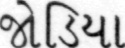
જોડિયા
